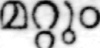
മറ്റും
